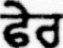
ਫੇਰ
